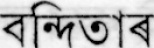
বন্দিতাৰ
